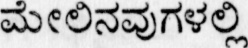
ಮೇಲಿನವುಗಳಲ್ಲಿ
